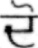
ਦੋ
